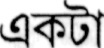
একটা
